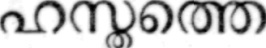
ഹസ്തത്തെ
